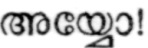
അയ്യോ!
